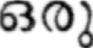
ഒരു
